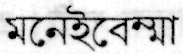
মনেইবেম্মা
